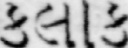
કલાક
